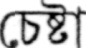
চেষ্টা
